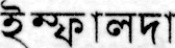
ইম্ফালদা
